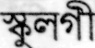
স্কুলগী
